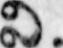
ವಿ.
